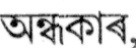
অন্ধকাৰ,
